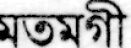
মতমগী
